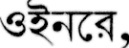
ওইনরে,
